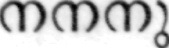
നനനു
